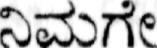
ನಿಮಗೇ
